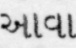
આવા
